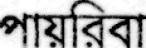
পায়রিবা
